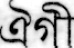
ঐগী
